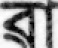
ৱা
